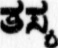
ತಸ್ಯ
